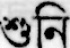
শুনি
